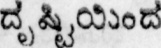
ದೃಷ್ಟಿಯಿಂದ
